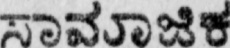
ಸಾಮಾಜಿಕ
